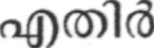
എതിര്‍
